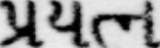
પ્રયત્ન
